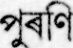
পুৰণি
